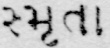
સ્મૃતા
